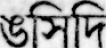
ঙসিদি
